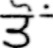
ਤੋਂ
